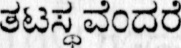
ತಟಸ್ಥವೆಂದರೆ
